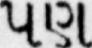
પણ
